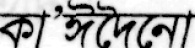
কা’ঈদৈনো
